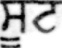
ਸੂਟ
